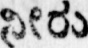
ನೀರು
